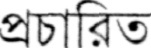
প্রচারিত
